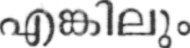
എങ്കിലും
